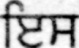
ਇਸ
